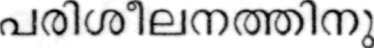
പരിശീലനത്തിനു
